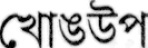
খোঙউপ
